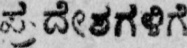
ಪ್ರದೇಶಗಳಿಗೆ
